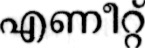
എണീറ്റ്
